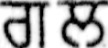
ਗਲ
